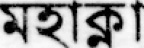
মহাক্না
